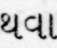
થવા
